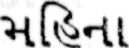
મહિના
